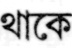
থাকে
